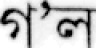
গ'ল
